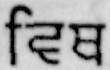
ਵਿਥ
